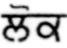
ਲੋਕ
